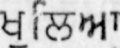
ਖੁਲ੍ਹਿਆ
